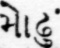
મોઢું
